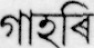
গাহৰি
